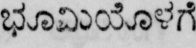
ಭೂಮಿಯೊಳಗೆ
